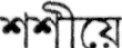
শশীয়ে
